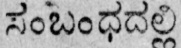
ಸಂಬಂಧದಲ್ಲಿ
